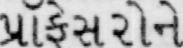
પ્રૉફેસરોને
